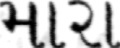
મારા
